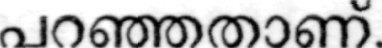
പറഞ്ഞതാണ്.
